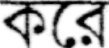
করে
